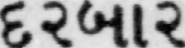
દરબાર
